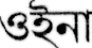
ওইনা
